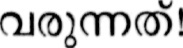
വരുന്നത്!”
